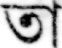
তা
